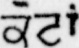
ਕੋਟਾਂ
